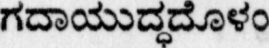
ಗದಾಯುದ್ಧದೊಳಂ
